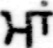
ਮਾਂ
